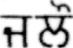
ਜਲੌ
